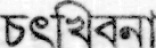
চৎখিবনা
